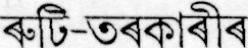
ৰুটি-তৰকাৰীৰ
